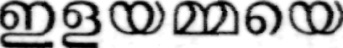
ഇളയമ്മയെ
